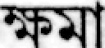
ক্ষমা
